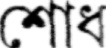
শোধ
